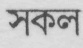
সকল
